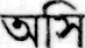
অসি
